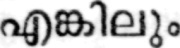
എങ്കിലും
